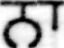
ਨਾ
